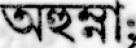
অহুম্না;
